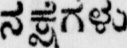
ನಕ್ಷೆಗಳು
